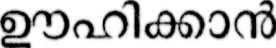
ഊഹിക്കാന്‍
